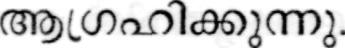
ആഗ്രഹിക്കുന്നു.
